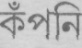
কঁপনি
